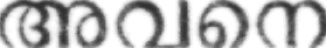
അവനെ
